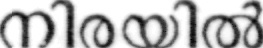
നിരയില്‍
